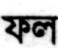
ফল
